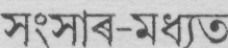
সংসাৰ-মধ্যত
